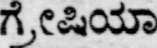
ಗ್ರೇಷಿಯಾ
